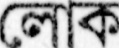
লোক
